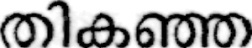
തികഞ്ഞ
